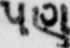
પણ
